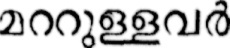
മററുള്ളവര്‍
